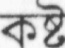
কষ্ট
